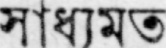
সাধ্যমত
